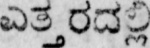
ಎತ್ತರದಲ್ಲಿ
